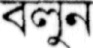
বলুন
